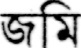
জমি
